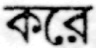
করে
